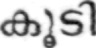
കൂടി
